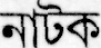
নাটক
